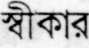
স্বীকার
